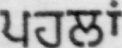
ਪਹਲਾਂ
